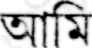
আমি
